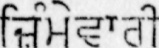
ਜ਼ਿੰਮੇਵਾਰੀ
